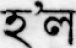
হ'ল
